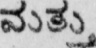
ಮತ್ತು
